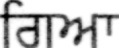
ਗਿਆ
